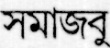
সমাজবু
